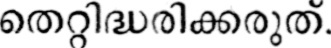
തെറ്റിദ്ധരിക്കരുത്.
